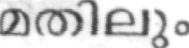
മതിലും
